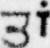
ਤਾਂ
